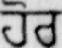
ਹੋਰ
